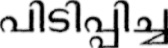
പിടിപ്പിച്ച
